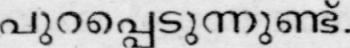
പുറപ്പെടുന്നുണ്ട്.
